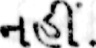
નહીં.
